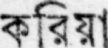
করিয়া
